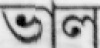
ভাল
